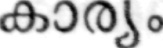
കാര്യം
